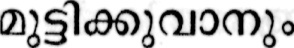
മുട്ടിക്കുവാനും
